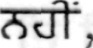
ਨਹੀਂ,
